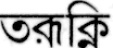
তরূক্নি
